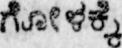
ಗೋಳಕ್ಕೆ
